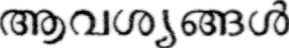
ആവശ്യങ്ങള്‍
